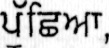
ਪੁੱਛਿਆ,
